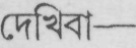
দেখিবা-
